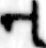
ન
